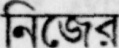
নিজের
